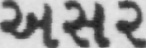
અસર
